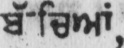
ਬੱਚਿਆਂ,
